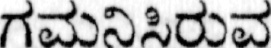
ಗಮನಿಸಿರುವ
